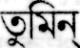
তুমিন্
